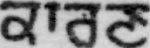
ਕਾਰਣ
